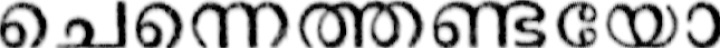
ചെന്നെത്തണ്ടയോ
